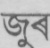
জুৰ
